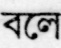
বলে
